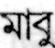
মাবু
